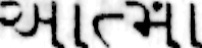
આત્મા
